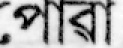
পোৱা
